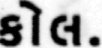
કોલ.
